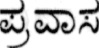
ಪ್ರವಾಸ
